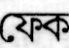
ফেক
